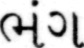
ભંગ
